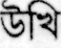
উখি
